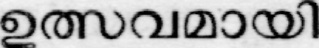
ഉത്സവമായി
